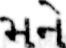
મને
